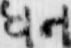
ધન
